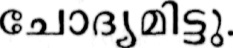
ചോദ്യമിട്ടു.
